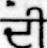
ਦੀ
